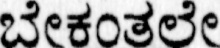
ಬೇಕಂತಲೇ
